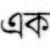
এক
